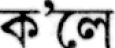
ক'লে
